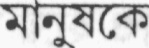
মানুষকে
